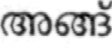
അങ്ങ്
